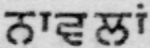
ਨਾਵਲਾਂ
